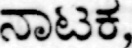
ನಾಟಕ,
